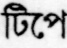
টিপে
